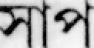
সাপ
